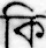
কি
